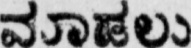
ಮಾಡಲು
